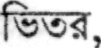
ভিতর,
